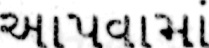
આપવામાં
